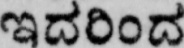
ಇದರಿಂದ
